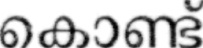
കൊണ്ട്
